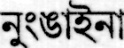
নুংঙাইনা
